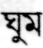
ঘুম
